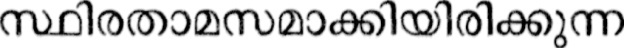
സ്ഥിരതാമസമാക്കിയിരിക്കുന്ന
